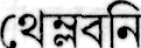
থেম্লবনি
